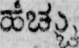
ಹೆಚ್ಚು
